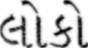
લોકો
